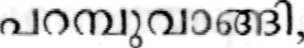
പറമ്പുവാങ്ങി,
